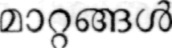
മാറ്റങ്ങള്‍
